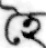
হৈ
